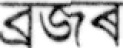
ব্রজৰ
